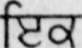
ਇਕ
